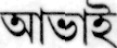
আভাই
